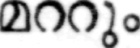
മററും
